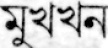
মুখখন
